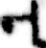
ન
